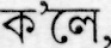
ক'লে,
